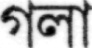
গলা
